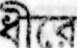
ধীরে
